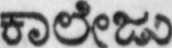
ಕಾಲೇಜು
